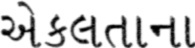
એકલતાના
